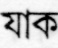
যাক
